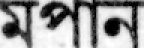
মপান
